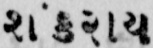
શંકરાય
